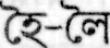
হৈ-লৈ
